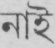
নাই
